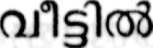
വീട്ടില്‍
